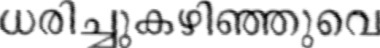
ധരിച്ചുകഴിഞ്ഞുവെ
